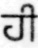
ਹੀ
